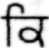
ਕਿ
